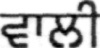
ਵਾਲੀ
